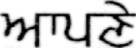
ਆਪਣੇ
